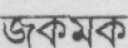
জকমক
